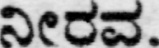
ನೀರವ.
